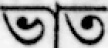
ভাত
